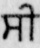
ਸੀ
